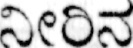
ನೀರಿನ
